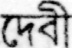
দেবী
